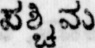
ಪಶ್ಚಿಮ
